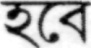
হবে
